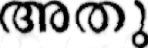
അതു
